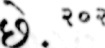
છે.૨૦૨
